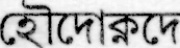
হৌদোক্নদে
